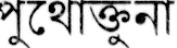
পুথোক্তুনা
